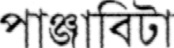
পাঞ্জাবিটা
